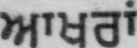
ਆਖਰਾਂ
